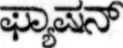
ಫ್ಯಾಷನ್
